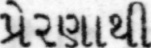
પ્રેરણાથી
